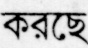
করছে
